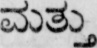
ಮತ್ತು
